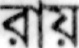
রায়
